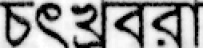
চৎখ্রবরা
